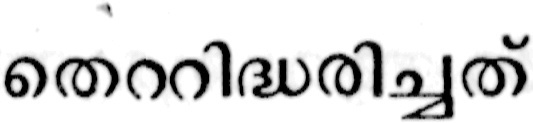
തെററിദ്ധരിച്ചത്
